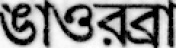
ঙাওরব্রা
